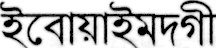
ইবোয়াইমদগী
